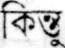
কিন্তু
